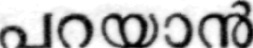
പറയാന്‍
